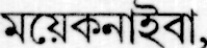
ময়েকনাইবা,
